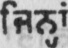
ਜਿਨ੍ਹਾਂ
